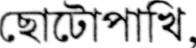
ছোটোপাখি,
